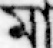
মা
